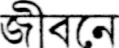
জীবনে
